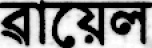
ৱায়েল
